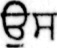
ਉਸ
